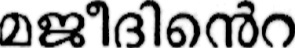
മജീദിന്റെ
